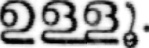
ഉള്ളൂ.
